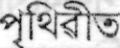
পৃথিৱীত
